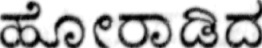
ಹೋರಾಡಿದ
